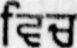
ਵਿਚ
